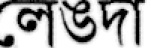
লেঙদা
